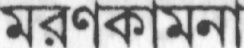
মরণকামনা
